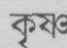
কৃষ্ণ
